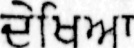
ਦੇਖਿਆ
